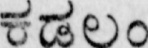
ಕಡಲಂ
